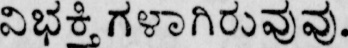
ವಿಭಕ್ತಿಗಳಾಗಿರುವುವು.
